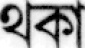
থকা
